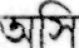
অসি
